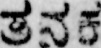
ತನಕ
